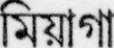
মিয়াগা
